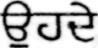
ਉਹਦੇ
